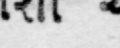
બનશો
